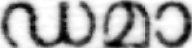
ഡമാ
